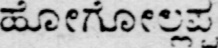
ಹೋಗೋಲ್ಲಪ್ಪ
